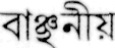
বাঞ্ছনীয়
